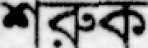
শরুক
